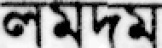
লমদম
